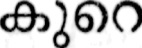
കുറെ
